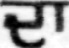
ਦਾ
